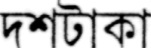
দশটাকা
